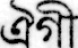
ঐগী
